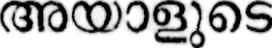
അയാളുടെ
